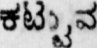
ಕಟ್ಟುವ
